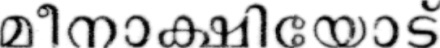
മീനാക്ഷിയോട്
